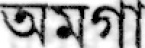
অমগা
